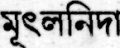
মূৎলনিদা
